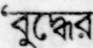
‘বুদ্ধের
